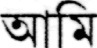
আমি
